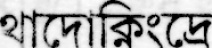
থাদোক্নিংদ্রে
